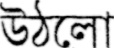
উঠলো
